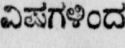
ವಿಷಗಳಿಂದ
